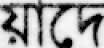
য়াদে
